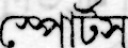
স্পোর্টস
